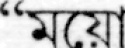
"ময়ো
